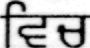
ਵਿਚ
